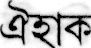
ঐহাক
